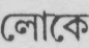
লোকে
